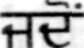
ਜਦੋਂ
